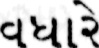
વધારે
